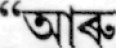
"আৰু
